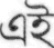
এই
